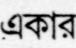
একার
